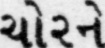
ચોરને
